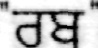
''ਰਬ''
